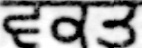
ਵਕਤ
